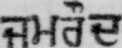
ਜਮਰੌਦ
